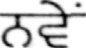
ਨਵੇਂ
